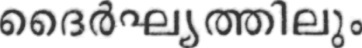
ദൈര്‍ഘ്യത്തിലും
